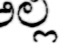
ಅಲ್ಲಿ
